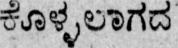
ಕೊಳ್ಳಲಾಗದ
